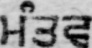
ਮੰਤਵ
